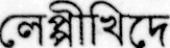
লেপ্পীখিদে
